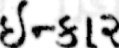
ઇન્કાર
